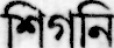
শিগনি
